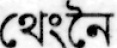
থেংনৈ
